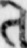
તે
